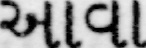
આવા
